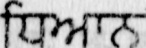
ਧਿਆਨ
